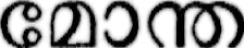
മോന്ത
